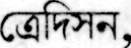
ত্রেদিসন,
